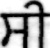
ਸੀ
